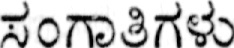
ಸಂಗಾತಿಗಳು
